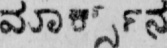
ಮಾರ್ಕ್ಸ್ ನ
